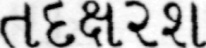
તદક્ષરશ
